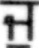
ਜੁ
